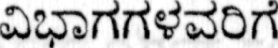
ವಿಭಾಗಗಳವರಿಗೆ
